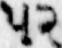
પર
